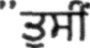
''ਤੁਸੀਂ
